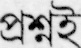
প্রশ্নই
